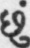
છું
